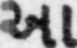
આ
